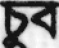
চুব
